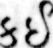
કઈ
